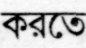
করতে
